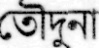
তৌদুনা
